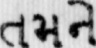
તમને
